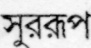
সুররূপ
